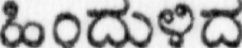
ಹಿಂದುಳಿದ
